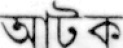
আটক
